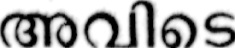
അവിടെ
